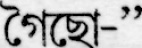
গৈছো-"
